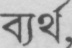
ব্যর্থ,
